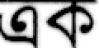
ত্রক
